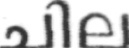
ചില
